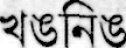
খঙনিঙ
